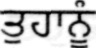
ਤੁਹਾਨੂੰ
